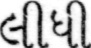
લીધી
